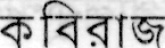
কবিরাজ
